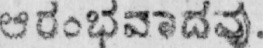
ಆರಂಭವಾದವು.
